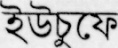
ইউচুফে
